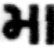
મા
